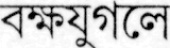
বক্ষযুগলে
